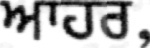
ਆਹਰ,
